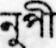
নুপী
